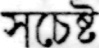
সচেষ্ট
